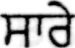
ਸਾਰੇ
